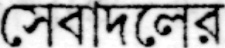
সেবাদলের
